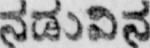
ನಡುವಿನ
